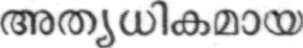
അത്യധികമായ
